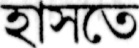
হাসতে
